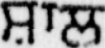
ਸ਼ਾਲ
